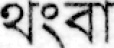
থংবা
